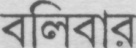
বলিবার
